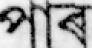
পাৰ
